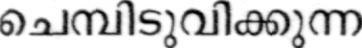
ചെമ്പിടുവിക്കുന്ന
